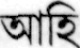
আহি
